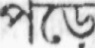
পড়ে
